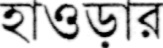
হাওড়ার
